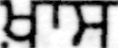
ਖ਼ਾਸ
